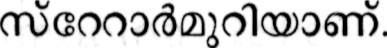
സ്റേറാര്‍മുറിയാണ്.
